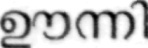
ഊന്നി
